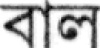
বাল
